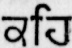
ਕਹਿ
